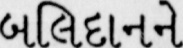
બલિદાનને
